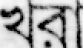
খরা
